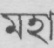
মহা
